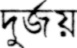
দুর্জয়
